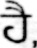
ਹੈ,
